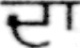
ਦਾ
